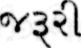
જરૂરી
